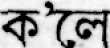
ক'লে
